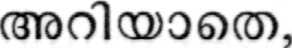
അറിയാതെ,
